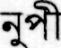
নুপী
